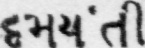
દમયંતી
